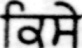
ਕਿਸੇ
